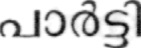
പാര്‍ട്ടി
